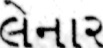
લેનાર
